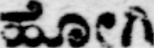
ಹೋಗಿ
